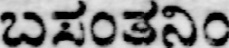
ಬಸಂತನಿಂ
